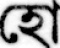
হো
